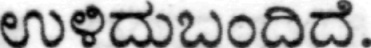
ಉಳಿದುಬಂದಿದೆ.
